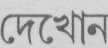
দেখোন
